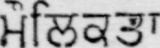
ਮੌਲਿਕਤਾ
